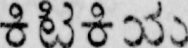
ಕಿಟಕಿಯ
